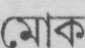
মোক
